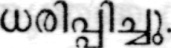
ധരിപ്പിച്ചു.
